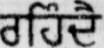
ਰਹਿੰਦੈ
